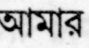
আমার
